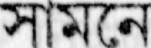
সামনে
